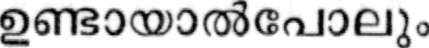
ഉണ്ടായാല്‍പോലും
